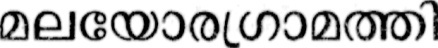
മലയോരഗ്രാമത്തി
